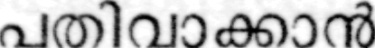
പതിവാക്കാന്‍
